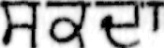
ਸਕਦਾ
